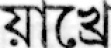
য়াখ্রে
